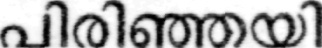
പിരിഞ്ഞയി
